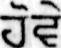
ਹੋਵੇ
